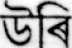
উৰি
